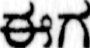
ಈಗ
